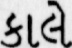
કાલે
